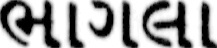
ભાગલા
